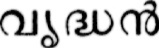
വൃദ്ധന്‍
